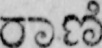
ರಾಣಿ
